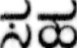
ಸಹ
